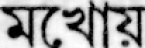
মখোয়
